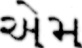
એમ
